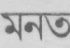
মনত
